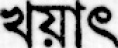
খয়াৎ
